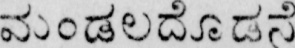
ಮಂಡಲದೊಡನೆ
